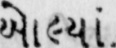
બોલ્યાં.
